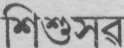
শিশুসৱ
